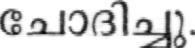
ചോദിച്ചു.
